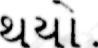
થયો.
